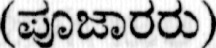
(ಪೂಜಾರರು)
